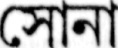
সোনা
